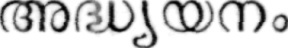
അദ്ധ്യയനം
